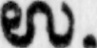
ಉ.
